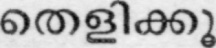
തെളിക്കൂ
